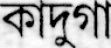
কাদুগা
